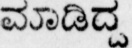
ಮಾಡಿದ್ದ
